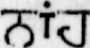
ਨਾਂਹ
